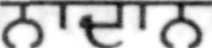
ਨਾਦਾਨ
